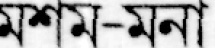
মশম-মনা
